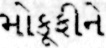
મોકૂફીને
